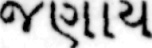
જણાય
